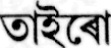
তাইৰো
